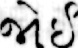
જોઈ
